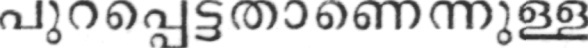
പുറപ്പെട്ടതാണെന്നുള്ള
